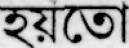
হয়তো
